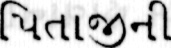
પિતાજીની
